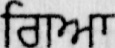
ਗਿਆ
